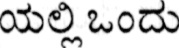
ಯಲ್ಲಿಒಂದು
